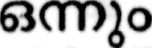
ഒന്നും
